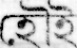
হৌই
